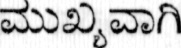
ಮುಖ್ಯವಾಗಿ
